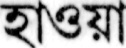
হাওয়া
